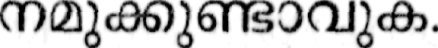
നമുക്കുണ്ടാവുക.
